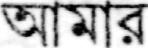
আমার
